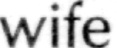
wife
